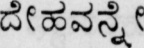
ದೇಹವನ್ನೇ
